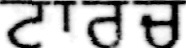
ਟਾਰਚ
